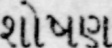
શોષણ
